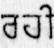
ਰਹੀ
